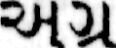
અગ્ર
